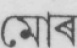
মোৰ
